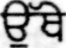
ਉੱਥੇ
